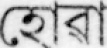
হোৱা
